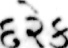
દરેક
